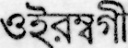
ওইরম্বগী
